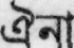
ঐনা
